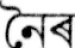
নৈৰ
